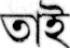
তাই
